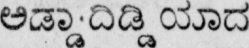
ಅಡ್ಡಾದಿಡ್ಡಿಯಾದ
